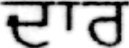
ਦਾਰ
